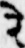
રે
